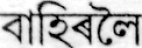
বাহিৰলৈ
